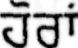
ਹੋਰਾਂ
